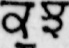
ਕੁਝ
